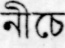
নীচে
